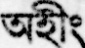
অহীং
